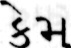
કેમ
